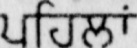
ਪਹਿਲਾਂ
